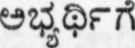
ಅಭ್ಯರ್ಥಿಗೆ
